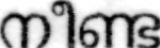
നീണ്ട
